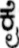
ಕೈ
